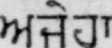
ਅਜੇਹਾ
